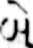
બે
